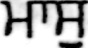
ਮਾਸੁ
